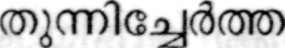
തുന്നിച്ചേര്‍ത്ത
